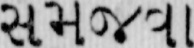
સમજવા
